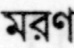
মরণ
